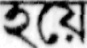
হয়ে
